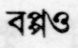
বপ্পও
